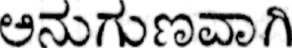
ಅನುಗುಣವಾಗಿ
